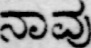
ನಾವು
